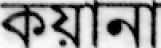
কয়ানা
